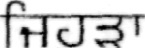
ਜਿਹੜਾ
